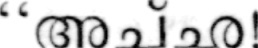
"അച്ഛ!
